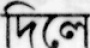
দিলে
